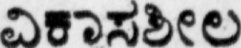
ವಿಕಾಸಶೀಲ
